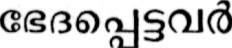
ഭേദപ്പെട്ടവര്‍
